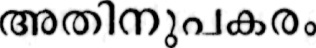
അതിനുപകരം
